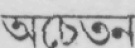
অচেতন
